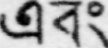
এবং
